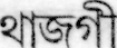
থাজগী
